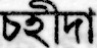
চহীদা
